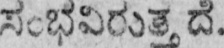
ಸಂಭವಿರುತ್ತದೆ.
